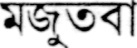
মজুতবা
